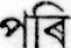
পৰি
